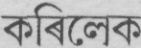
কৰিলেক
